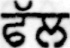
ਫੱਲ
